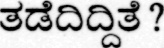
ತಡೆದಿದ್ದಿತೆ?
